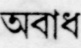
অবাধ
